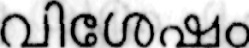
വിശേഷം
